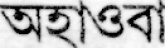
অহাওবা
